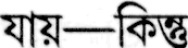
যায়-কিন্তু
